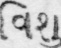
વિશુ
